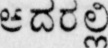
ಅದರಲ್ಲಿ
